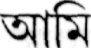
আমি
